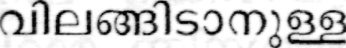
വിലങ്ങിടാനുള്ള
